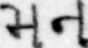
મન
